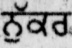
ਨੁੱਕਰ
